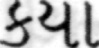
કયા
